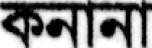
কনানা
